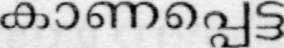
കാണപ്പെട്ട
